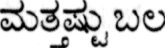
ಮತ್ತಷ್ಟುಬಲ
